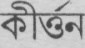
কীৰ্ত্তন
